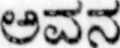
ಅವನ
